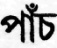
পাঁচ
